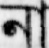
না
